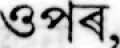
ওপৰ,
